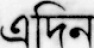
এদিন
